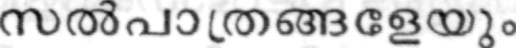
സല്‍പാത്രങ്ങളേയും
